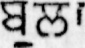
ਬੁਲਾ
